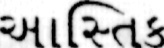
આસ્તિક
